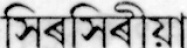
সিৰসিৰীয়া
